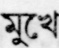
মুখে
